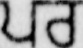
ਪਰ
